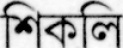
শিকলি
